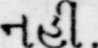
નહીં.
